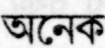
অনেক
